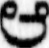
ಆ
